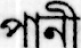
পানী
